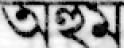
অহুম
